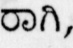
ರಾಗಿ,
